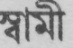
স্বামী
